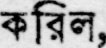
করিল,
